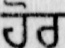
ਹੋਰ
